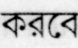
করবে
